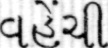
વહેંચી
